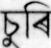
চুৰি
